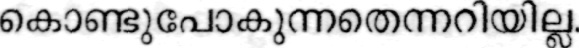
കൊണ്ടുപോകുന്നതെന്നറിയില്ല.
